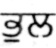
ਭੁਲ
